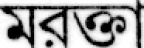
মরক্তা
